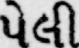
પેલી
